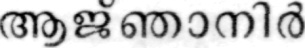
ആജ്ഞാനിര്‍
